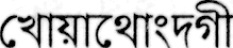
খোয়াথোংদগী
